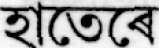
হাতেৰে
